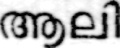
ആലി
